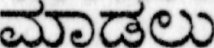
ಮಾಡಲು
